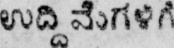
ಉದ್ದಿಮೆಗಳಿಗೆ
